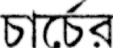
চার্চের
